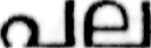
പല
